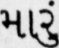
મારું
